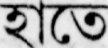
হাতে
